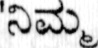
‘ನಿಮ್ಮ
